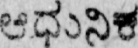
ಆಧುನಿಕ
